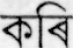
কৰি
